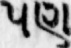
પણ
